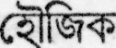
হৌজিক
